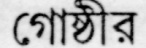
গোষ্ঠীর
